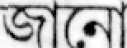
জানো
